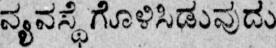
ವ್ಯವಸ್ಥೆಗೊಳಿಸಿಡುವುದು
